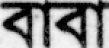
বাবা
